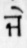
ਜੇ
